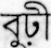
বুঢ়ী
